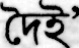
দৈই’
